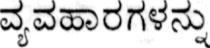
ವ್ಯವಹಾರಗಳನ್ನು
